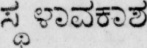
ಸ್ಥಳಾವಕಾಶ
